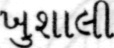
ખુશાલી
